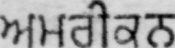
ਅਮਰੀਕਨ
